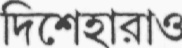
দিশেহারাও
